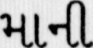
માની
